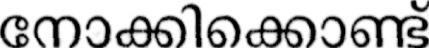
നോക്കിക്കൊണ്ട്
